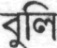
বুলি
